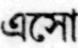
এসো
